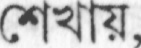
শেখায়,
